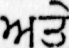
ਅਤੇ
